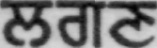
ਲਗਣ
